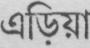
এড়িয়া
